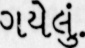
ગયેલું.
